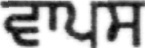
ਵਾਪਸ
